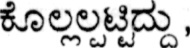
ಕೊಲ್ಲಲ್ಪಟ್ಟಿದ್ದು,
